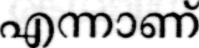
എന്നാണ്
